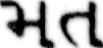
મત
